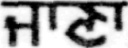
ਜਾਣਾ
